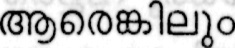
ആരെങ്കിലും
